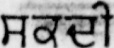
ਸਕਦੀ
